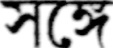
সঙ্গে
